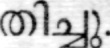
തിച്ചു.
